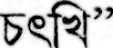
চৎখি”
